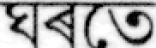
ঘৰতে
